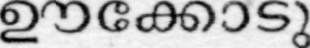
ഊക്കോടു
